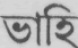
ভাহি
